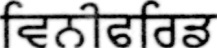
ਵਿਨੀਫਰਿਡ
